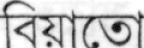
বিয়াতো
